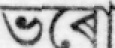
ভৰো
